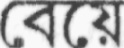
বেয়ে
